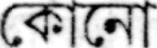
কোনো
